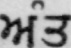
ਅੰਤ
